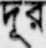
দূর
